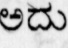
ಅದು
